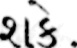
શકે.
